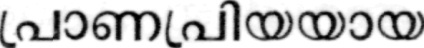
പ്രാണപ്രിയയായ
